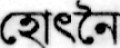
হোৎনৈ
